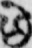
છે
